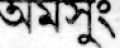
অমসুং
